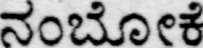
ನಂಬೋಕೆ
